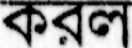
করল
